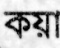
কয়া
